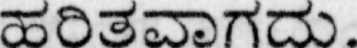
ಹರಿತವಾಗದು.
